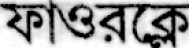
ফাওরক্লে
